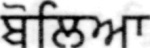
ਬੋਲਿਆ
